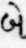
બે
